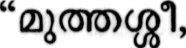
“മുത്തശ്ശീ,
